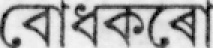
বোধকৰো
